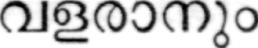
വളരാനും
